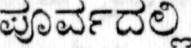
ಪೂರ್ವದಲ್ಲಿ
